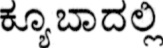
ಕ್ಯೂಬಾದಲ್ಲಿ
